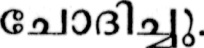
ചോദിച്ചു.
